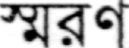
স্মরণ
